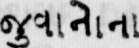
જુવાનોના
